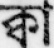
ক্বা
